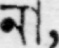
না,
